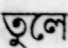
তুলে
